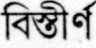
বিস্তীর্ণ
